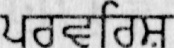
ਪਰਵਰਿਸ਼
